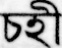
চহী
